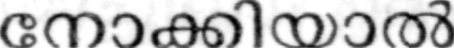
നോക്കിയാല്‍
